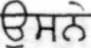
ਉਸਨੇ
